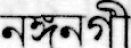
নঙ্গনগী
